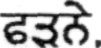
ਫੜਨੇ,
